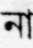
না
